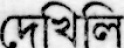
দেখিলি
